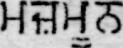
ਮਜ਼ਮੂਨ
